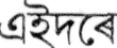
এইদৰে
